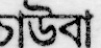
চাউবা
